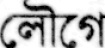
লৌগে
